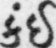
કંઈ
